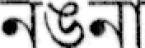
নঙনা
